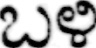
ಬಳಿ
